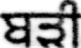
ਬੜੀ
